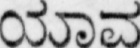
ಯಾವ
